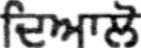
ਦਿਆਲੋ
